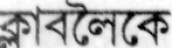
ক্লাবলৈকে
